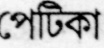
পেটিকা
